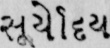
સૂર્યોદય
